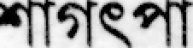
শাগৎপা
